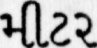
મીટર
